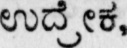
ಉದ್ರೇಕ,
